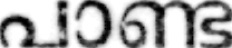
പാണ്ട
